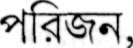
পরিজন,
